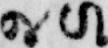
જળ
